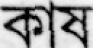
কাষ
